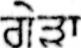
ਗੇੜਾ
